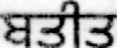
ਬਤੀਤ
